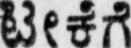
ಟೀಕೆಗೆ
